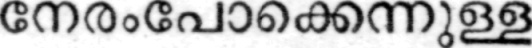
നേരംപോക്കെന്നുള്ള
